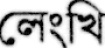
লেংখি
